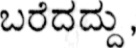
ಬರೆದದ್ದು,
